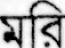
মরি
